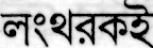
লংথরকই
